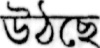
উঠছে
